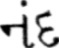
નંદ
